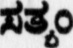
ಸತ್ಯ೦
